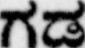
ಗಡ
